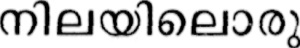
നിലയിലൊരു
